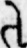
તે
